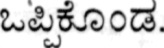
ಒಪ್ಪಿಕೊಂಡ.
